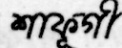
শাফূগী
